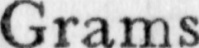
Grams
